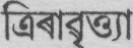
ত্ৰিৰাৱৃত্ত্যা
